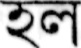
হল
